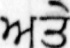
ਅਤੇ
